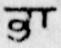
ਭਾ
